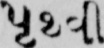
પૃથ્વી
